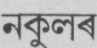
নকুলৰ
